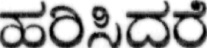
ಹರಿಸಿದರೆ
